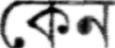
কেন
